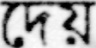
দেয়
